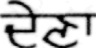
ਦੇਣਾ
